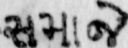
સમાજે
